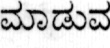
ಮಾಡುವ
